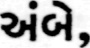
અંબ,
